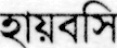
হায়বসি
